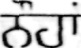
ਨੌਹਾਂ
